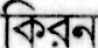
কিরন
